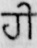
ਹੀ
